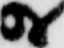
જ
